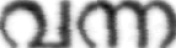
വന്ന
